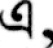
এ,
